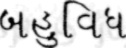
બહુવિધ
